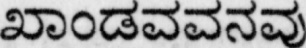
ಖಾಂಡವವನವು
